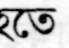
হতে
